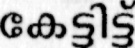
കേട്ടിട്ട്
